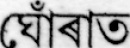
ঘোঁৰাত
